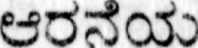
ಆರನೆಯ
